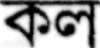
কল
